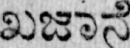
ಖಜಾನೆ
